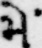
મેં
